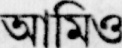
আমিও
